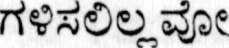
ಗಳಿಸಲಿಲ್ಲವೋ
